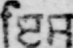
ਇਸ
